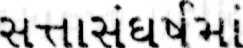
સત્તાસંઘર્ષમાં
